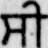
ਸੀ
